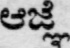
ಆಜ್ಞೆ
